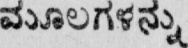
ಮೂಲಗಳನ್ನು
